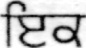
ਇਕ
